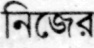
নিজের
